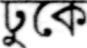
ঢুকে
